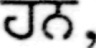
ਹਨ,
